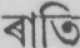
ৰাতি
